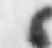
ને
